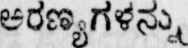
ಅರಣ್ಯಗಳನ್ನು
